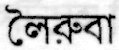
লৈরুবা
